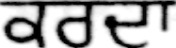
ਕਰਦਾ
